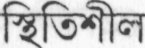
স্থিতিশীল
